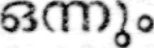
ഒന്നും
